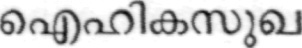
ഐഹികസുഖ
